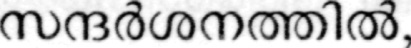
സന്ദര്‍ശനത്തില്‍,
